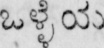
ಒಳ್ಳೆಯ
